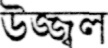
উজ্জ্বল
